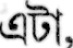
এটা,
